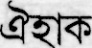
ঐহাক
